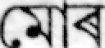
মোৰ
